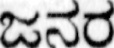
ಜನರ
